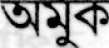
অমুক
